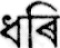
ধৰি
